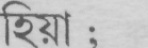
হিয়া;
